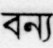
বন্য
